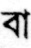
বা
